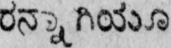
ರನ್ನಾಗಿಯೂ
